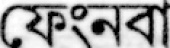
ফেংনবা
